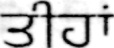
ਤੀਹਾਂ
